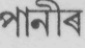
পানীৰ
